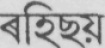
ৰহিছয়
